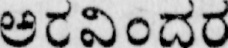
ಅರವಿಂದರ
